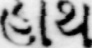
હાથ
